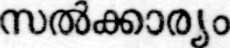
സല്‍ക്കാര്യം
